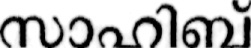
സാഹിബ്
